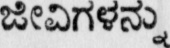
ಜೀವಿಗಳನ್ನು
